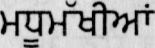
ਮਧੂਮੱਖੀਆਂ
